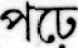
পঢ়ে
